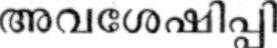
അവശേഷിപ്പി
